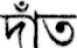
দাঁত
